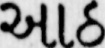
આઠ
